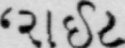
'રાઈટ
